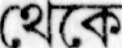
থেকে
